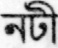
নটী
